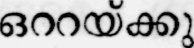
ഒററയ്ക്കു
